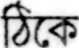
ঠিকে
